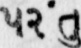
પરંતુ
